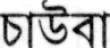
চাউবা
